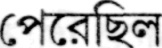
পেরেছিল
